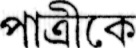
পাত্রীকে
